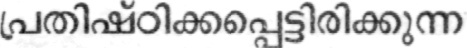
പ്രതിഷ്ഠിക്കപ്പെട്ടിരിക്കുന്ന
